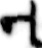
ન
